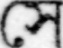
সে
